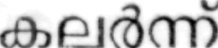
കലര്‍ന്ന്
